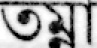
তম্না
